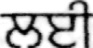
ਲਈ
